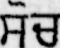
ਸੋਚ
